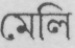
মেলি
